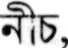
নীচ,
